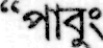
“পাবুং
